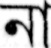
না
